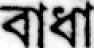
বাধা
